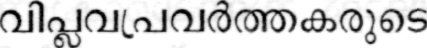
വിപ്ലവപ്രവര്‍ത്തകരുടെ
